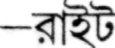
-রাইট
